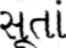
સૂતાં
